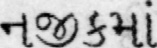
નજીકમાં
